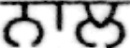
ਨਾਲ
